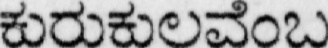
ಕುರುಕುಲವೆಂಬ
